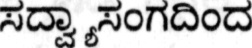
ಸದ್ವ್ಯಾಸಂಗದಿಂದ
